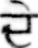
ਦੇ
